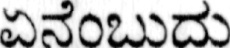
ಏನೆಂಬುದು
